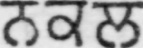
ਨਕਲ
